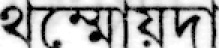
থম্মোয়দা
